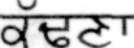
ਕੱਢਣਾ
